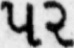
પર
